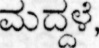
ಮದ್ದಳೆ,
